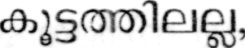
കൂട്ടത്തിലല്ല,
